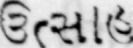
ઉત્સાહ
